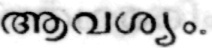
ആവശ്യം.
